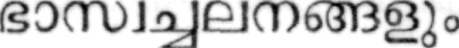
ഭാസ്വച്ചലനങ്ങളും
